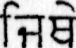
ਜਿਥੇ
